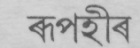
ৰূপহীৰ
